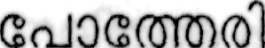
പോത്തേരി
